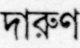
দারুণ
